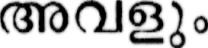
അവളും
